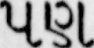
પણ
